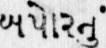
બપોરનું
